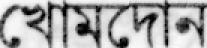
খোমদোন
